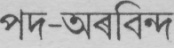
পদ-অৰবিন্দ
